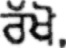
ਰੱਖੋ,
